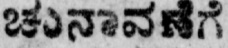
ಚುನಾವಣೆಗೆ
